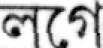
লগে
